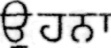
ਉਹਨਾ
